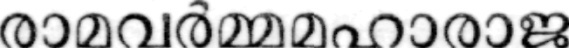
രാമവര്‍മ്മമഹാരാജ
